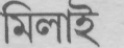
মিলাই
